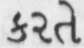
કરતે
